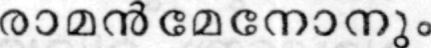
രാമന്‍മേനോനും
